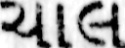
ચાલ
